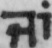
ਜਾਂ
